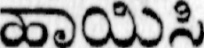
ಹಾಯಿಸಿ
